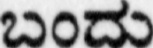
ಬಂದು
